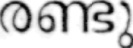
രണ്ടു
